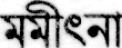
মমীৎনা
